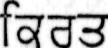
ਕਿਰਤ
